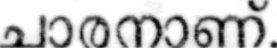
ചാരനാണ്.
